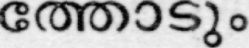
ത്തോടും
